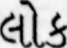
લોક
